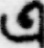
এ
